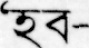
'হব-
